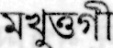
মখুত্তগী
